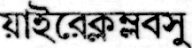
য়াইরেক্লম্লবসু
